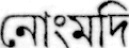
নোংমদি
